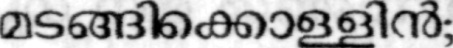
മടങ്ങിക്കൊള്ളിന്‍;
